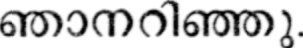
ഞാനറിഞ്ഞു.
